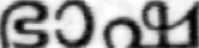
ഭാഷ
